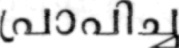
പ്രാപിച്ച
